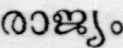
രാജ്യം
